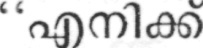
"എനിക്ക്
